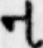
ન
